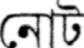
নোট
